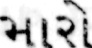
મારો
